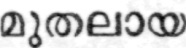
മുതലായ
